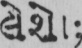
લેશો;
